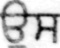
ਉਸ
